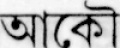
আকৌ
